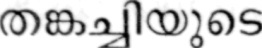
തങ്കച്ചിയുടെ
